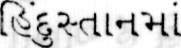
હિંદુસ્તાનમાં
